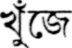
খুঁজে
